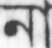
না
